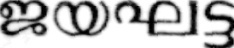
ജയഘട്ട
